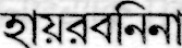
হায়রবনিনা
